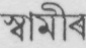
স্বামীৰ
